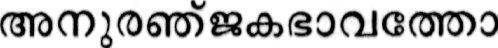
അനുരഞ്ജകഭാവത്തോ
